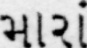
મારાં
